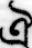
ঐ
